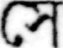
সে
